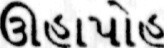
ઊહાપોહ
